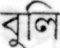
বুলি
